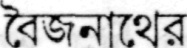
বৈজনাথের
